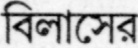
বিলাসের
